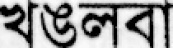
খঙলবা
